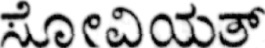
ಸೋವಿಯತ್
